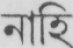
নাহি
